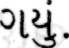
ગયું.
